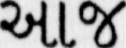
આજ
